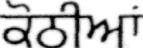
ਕੋਠੀਆਂ
